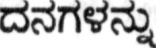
ದನಗಳನ್ನು
